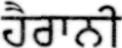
ਹੈਰਾਨੀ
